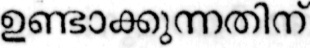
ഉണ്ടാക്കുന്നതിന്
